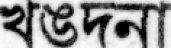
খঙদনা
